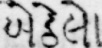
બેઠેલો
